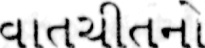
વાતચીતનો
